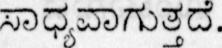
ಸಾಧ್ಯವಾಗುತ್ತದೆ.
